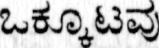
ಒಕ್ಕೂಟವು
